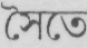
সৈতে
